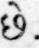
છે.
